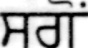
ਸਗੋਂ
